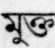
মুক্ত
